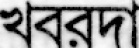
খবরদা
